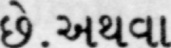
છે.અથવા
